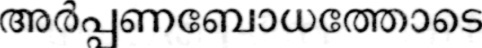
അര്‍പ്പണബോധത്തോടെ
